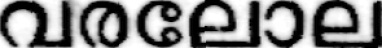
വരലോല
